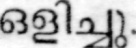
ഒളിച്ചു.
